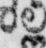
ರಲ್ಲಿ
